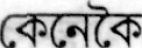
কেনেকৈ
